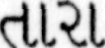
તારા
